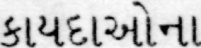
કાયદાઓના
